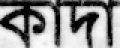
কাদা
